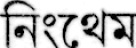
নিংথেম
